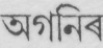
অগনিৰ
